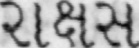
રાક્ષસ
